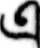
এ
